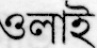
ওলাই
